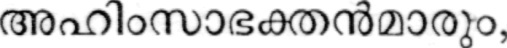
അഹിംസാഭക്തന്‍മാരും,
